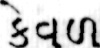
કેવળ
